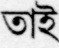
তাই
